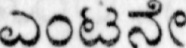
ಎಂಟನೇ
